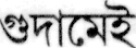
গুদামেই
